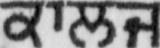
ਕਾਲਜ
